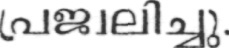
പ്രജ്വലിച്ചു.
